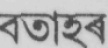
বতাহৰ
